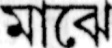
মাঝে
